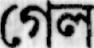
গেল
